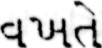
વખતે
